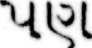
પણ
